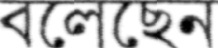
বলেছেন
